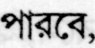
পারবে,
